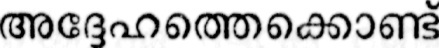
അദ്ദേഹത്തെക്കൊണ്ട്
